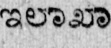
ಇಲಾಖಾ
